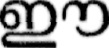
ഈ
